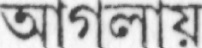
আগলায়
